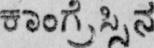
ಕಾಂಗ್ರೆಸ್ಸಿನ
